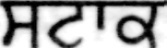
ਸਟਾਕ
